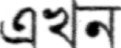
এখন
